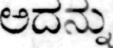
ಅದನ್ನು
